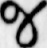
જ
